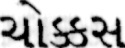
ચોક્કસ
